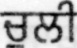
ਚੁਲੀ
